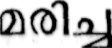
മരിച്ച
